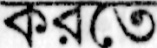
করতে
